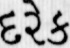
દરેક
